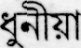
ধুনীয়া
